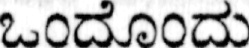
ಒಂದೊಂದು
